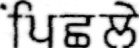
ਪਿਛਲੇ
